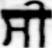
ਸੀ
